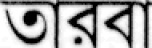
তারবা
